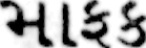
માફક
